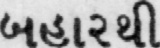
બહારથી
